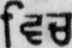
ਵਿਚ
